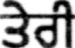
ਤੇਰੀ
